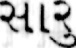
સારુ
